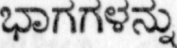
ಭಾಗಗಳನ್ನು
